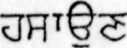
ਹਸਾਉਣ
